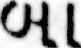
બા
